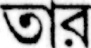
তার
